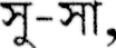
সু-সা,
